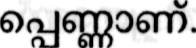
പ്പെണ്ണാണ്.
